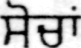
ਸੋਚਾਂ
